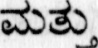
ಮತ್ತು
